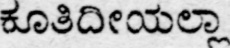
ಕೂತಿದೀಯಲ್ಲಾ
